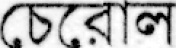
চেরোল
